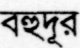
বহুদূর
